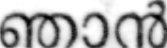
ഞാന്‍
